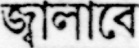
জ্বালাবে
